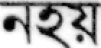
নহয়
